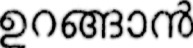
ഉറങ്ങാന്‍
